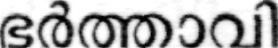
ഭര്‍ത്താവി
